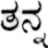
ತನ್ನ
